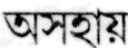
অসহায়
